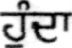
ਹੁੰਦਾ
